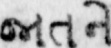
જાતને
